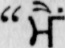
''ਮੈਂ
